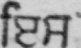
ਇਸ
